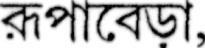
রূপাবেড়া,
